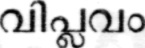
വിപ്ലവം
